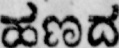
ಹಣದ
